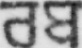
ਰਬ
